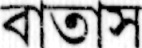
বাতাস
